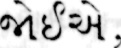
જોઈએ,
